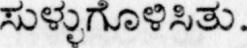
ಸುಳ್ಳುಗೊಳಿಸಿತು.
